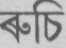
ৰুচি
